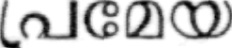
പ്രമേയ
